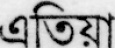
এতিয়া
